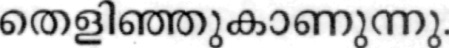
തെളിഞ്ഞുകാണുന്നു.
